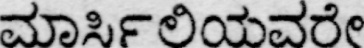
ಮಾರ್ಸಿಲಿಯವರೇ
